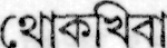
থোকখিবা
